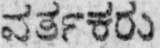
ವರ್ತಕರು
